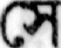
সে
